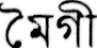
মৈগী
